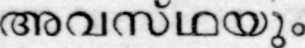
അവസ്ഥയും
